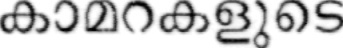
കാമറകളുടെ
